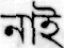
নাই
